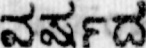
ವರ್ಷದ
